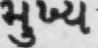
મુખ્ય
